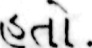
હતો.
